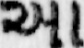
આ
